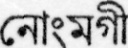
নোংমগী
